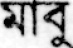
মাবু
